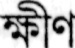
ক্ষীণ
